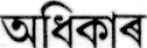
অধিকাৰ
